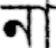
না
